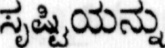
ಸೃಷ್ಟಿಯನ್ನು
